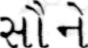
સૌને
